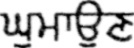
ਘੁਮਾਉਣ
